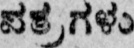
ಪತ್ರಗಳು
